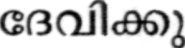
ദേവിക്കു
